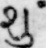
શું
